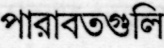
পারাবতগুলি
